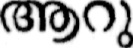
ആറു
